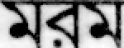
মরম
